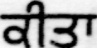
ਕੀਤਾ
